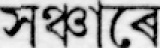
সঞ্চাৰে
